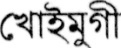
খোইমুগী
